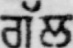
ਗੱਲ
